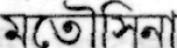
মতৌসিনা
